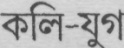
কলি-যুগ
